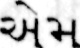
એમ
